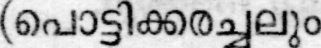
(പൊട്ടിക്കരച്ചലും
